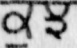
ਕੁਝ
